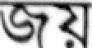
জয়
